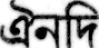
ঐনদি
